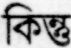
কিন্তু
